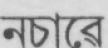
নচাৱে
